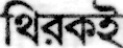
থিরকই
